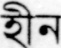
হীন
